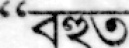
"বহুত
